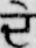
ਦੇ
